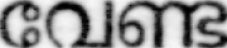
വേണ്ട
